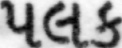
પલક
